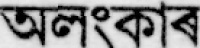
অলংকাৰ
